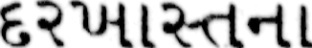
દરખાસ્તના
